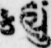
કહ્યું
